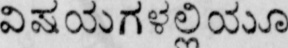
ವಿಷಯಗಳಲ್ಲಿಯೂ
